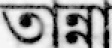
তান্না
